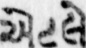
એટલે
